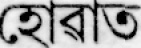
হোৱাত
